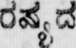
ರಷ್ಯದ
